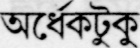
অর্ধেকটুকু
